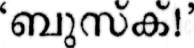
'ബുസ്ക്!'
